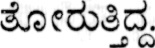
ತೋರುತ್ತಿದ್ದ.
